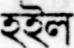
হইল
